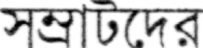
সম্রাটদের
